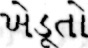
ખેડૂતો
